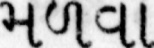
મળવા
